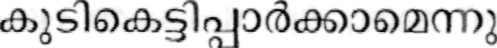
കുടികെട്ടിപ്പാര്‍ക്കാമെന്നു
